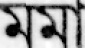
মমা
